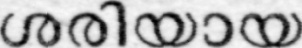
ശരിയായ
